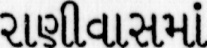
રાણીવાસમાં
